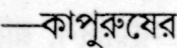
–কাপুরুষের
